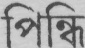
পিন্ধি
